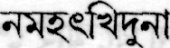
নমহৎখিদুনা
